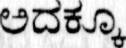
ಅದಕ್ಕೂ
